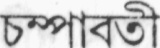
চম্পাবতী
